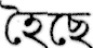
হৈছে
